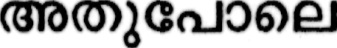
അതുപോലെ
